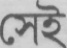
সেই
